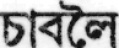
চাবলৈ
